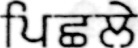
ਪਿਛਲੇ
